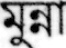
মুন্না
